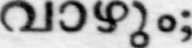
വാഴും;
